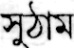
সুঠাম
